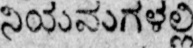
ನಿಯಮಗಳಲ್ಲಿ
